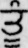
ਤੂੰ
